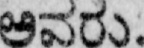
ಅವರು.
